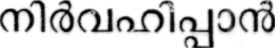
നിര്‍വഹിപ്പാന്‍
